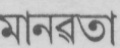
মানৱতা
